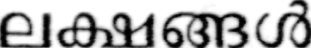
ലക്ഷങ്ങള്‍
